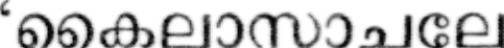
'കൈലാസാചലേ
